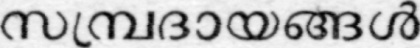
സമ്പ്രദായങ്ങള്‍
